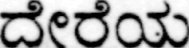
ದೇರೆಯ
